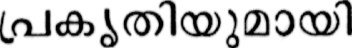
പ്രകൃതിയുമായി
